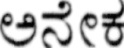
ಅನೇಕ
